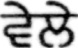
ਵੇਲੇ
